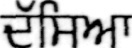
ਦੱਸਿਆ
